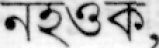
নহওক,
